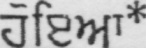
ਹੋਇਆ*
